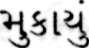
મુકાયું
